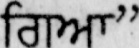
ਗਿਆ''
